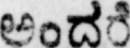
ಅಂದರೆ
